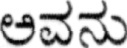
ಅವನು
